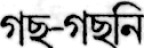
গছ-গছনি
